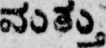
ಮತ್ತು
